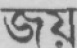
জয়
